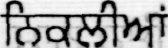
ਨਿਕਲੀਆਂ
